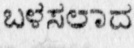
ಬಳಸಲಾದ
